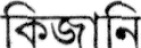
কিজানি
